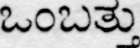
ಒಂಬತ್ತು
